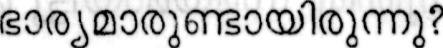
ഭാര്യമാരുണ്ടായിരുന്നു?
